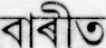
বাৰীত
